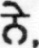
ਨੇ,
